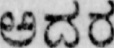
ಅದರ
